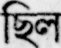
ছিল
